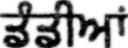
ਡੰਡੀਆਂ
